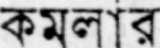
কমলার
